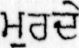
ਮੁਰਦੇ
